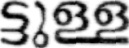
ട്ടുള്ള
